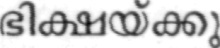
ഭിക്ഷയ്ക്കു
